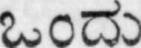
ಒಂದು
